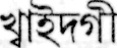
খ্বাইদগী
